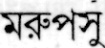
মরুপসু
